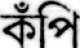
কঁপি
